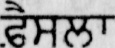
ਫ਼ੈਸਲਾ
